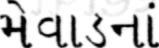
મેવાડનાં
